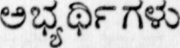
ಅಭ್ಯರ್ಥಿಗಳು
